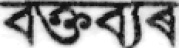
বক্তব্যৰ
